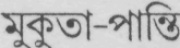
মুকুতা-পান্তি
